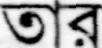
তার
